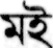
মই
